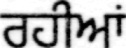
ਰਹੀਆਂ
